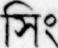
সিং
